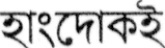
হাংদোকই
